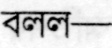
বলল–
